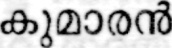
കുമാരന്‍
